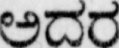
ಅದರ
